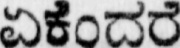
ಏಕೆಂದರೆ
